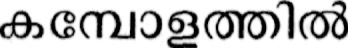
കമ്പോളത്തില്‍
